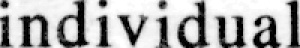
individual
